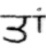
ਤਾਂ
